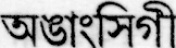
অঙাংসিগী
